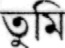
তুমি
